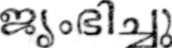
ജൃംഭിച്ചു
